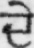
ਦੇ
